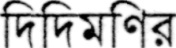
দিদিমণির
